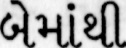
બેમાંથી
